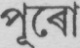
পূৰো
